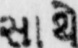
સાથે
